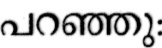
പറഞ്ഞു:
